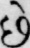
છે
